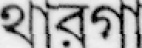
থারগা
